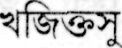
খজিক্তসু
